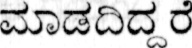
ಮಾಡದಿದ್ದರೆ
